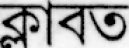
ক্লাবত
